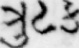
ત્રુટક
